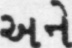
અને
